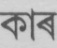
কাৰ
